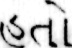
હતો
